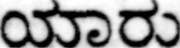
ಯಾರು
